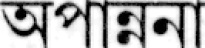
অপান্ননা
